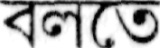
বলতে
